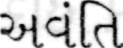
અવંતિ
